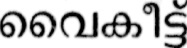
വൈകീട്ട്
